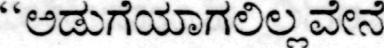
"ಅಡುಗೆಯಾಗಲಿಲ್ಲವೇನೆ
